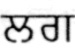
ਲਗ
